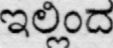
ಇಲ್ಲಿಂದ
